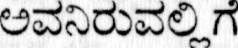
ಅವನಿರುವಲ್ಲಿಗೆ
